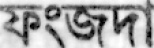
ফংজদা
